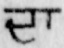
ਦਾ
